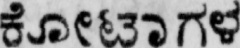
ಕೋಟಾಗಳ
